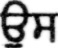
ਉਸ
